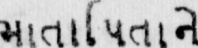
માતાપિતાને
